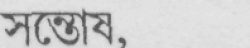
সন্তোষ,
